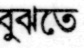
বুঝতে
